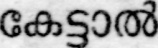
കേട്ടാല്‍
